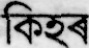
কিহৰ
